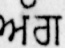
ਅੱਗ
